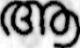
ആ
